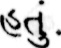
હતું.
